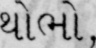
થોભો,
